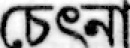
চেৎনা
